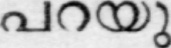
പറയു
